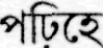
পঢ়িহে
